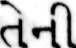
તેની
